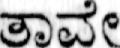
ತಾವೇ
